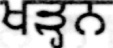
ਖੜ੍ਹਨ
